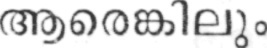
ആരെങ്കിലും
